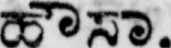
ಹೌಸಾ.
